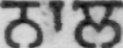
ਨਾਲ
